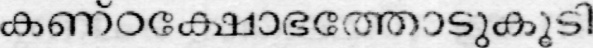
കണ്ഠക്ഷോഭത്തോടുകൂടി
